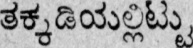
ತಕ್ಕಡಿಯಲ್ಲಿಟ್ಟು
